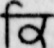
ਕਿ
